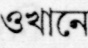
ওখানে
